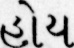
હોય
